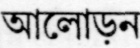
আলোড়ন
